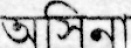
অসিনা
